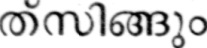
ത്സിങ്ങും
